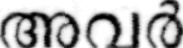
അവര്‍
